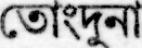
তোংদুনা
